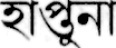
হাপ্তুনা
